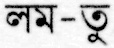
লম-তু
